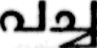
പച്ച
